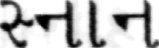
સ્નાન
